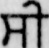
ਸੀ
